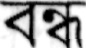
বন্ধ
